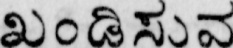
ಖಂಡಿಸುವ
